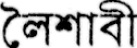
লৈশাবী
